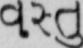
વસ્તુ
